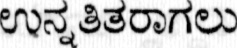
ಉನ್ನತಿತರಾಗಲು
